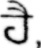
ਹੈ,
